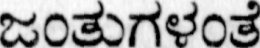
ಜಂತುಗಳಂತೆ
